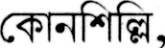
কোনশিল্লি,
